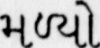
મળ્યો
